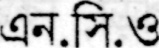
এন.সি.ও
